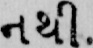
નથી.
